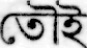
তৌই
